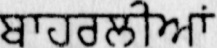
ਬਾਹਰਲੀਆਂ
